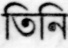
তিনি
